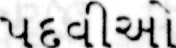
પદવીઓ
